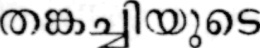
തങ്കച്ചിയുടെ
